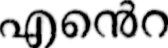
എന്റെ
